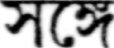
সঙ্গে
